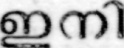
ഇനി
